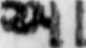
આ
